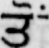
ਤੋਂ
